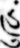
હું
